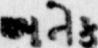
અનેક
